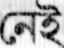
নেই
